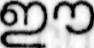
ഈ
